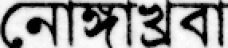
নোঙ্গাখ্রবা
